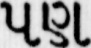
પણ
